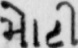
મોટી
